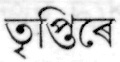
তৃপ্তিৰে
